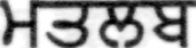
ਮਤਲਬ
